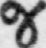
જ
